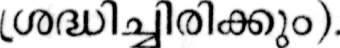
ശ്രദ്ധിച്ചിരിക്കും).
